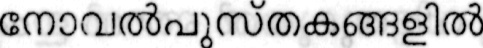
നോവല്‍പുസ്തകങ്ങളില്‍
